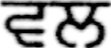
ਵਲ
